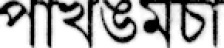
পাখঙমচা
